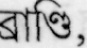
ব্রাণ্ডি,
